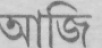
আজি
